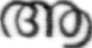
ആ
